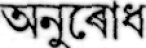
অনুৰোধ
